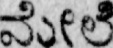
ಮೇಲೆ
